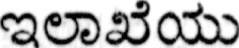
ಇಲಾಖೆಯು
